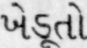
ખેડૂતો
